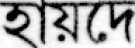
হায়দে
